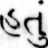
હતું
